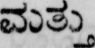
ಮತ್ತು
